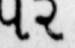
પર
